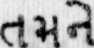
તમને
